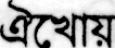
ঐখোয়
